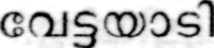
വേട്ടയാടി
